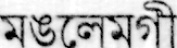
মঙলেমগী
